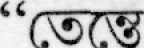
"তেন্তে
